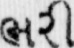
ભરી
